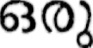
ഒരു
